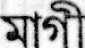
মাগী
